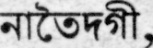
নাতৈদগী,
